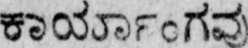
ಕಾರ್ಯಾಂಗವು
